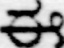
ಈ
